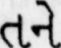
તને
